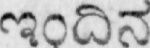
ಇಂದಿನ
